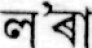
ল'ৰা
